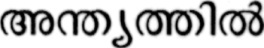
അന്ത്യത്തില്‍
